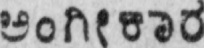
ಅಂಗೀಕಾರ
